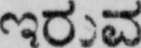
ಇರುವ
